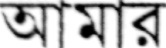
আমার
